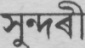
সুন্দৰী
